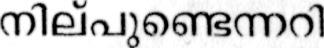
നില്പുണ്ടെന്നറി
